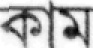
কাম
